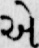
એ
